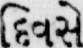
દિવસે
